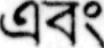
এবং
